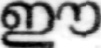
ഈ
